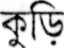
কুড়ি
